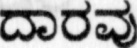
ದಾರವು
